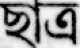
ছাত্র
